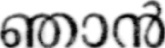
ഞാന്‍
